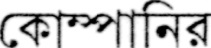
কোম্পানির
